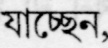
যাচ্ছেন,
